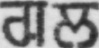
ਗਲ
